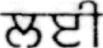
ਲਈ
